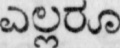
ಎಲ್ಲರೂ
